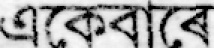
একেবাৰে
